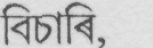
বিচাৰি,
